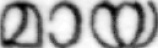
മായ
